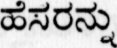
ಹೆಸರನ್ನು
